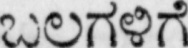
ಬಲಗಳಿಗೆ
